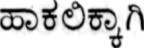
ಹಾಕಲಿಕ್ಕಾಗಿ
